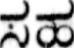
ಸಹ
